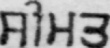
ਸੀਮਤ
